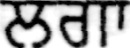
ਲਗਾ
